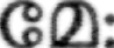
മേ:
